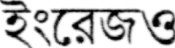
ইংরেজও
